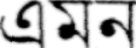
এমন
